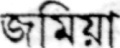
জমিয়া
